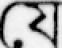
যে
